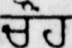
ਚੌਂਹ
